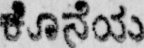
ಕೊನೆಯ
